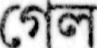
গেল
